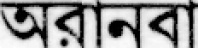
অরানবা
